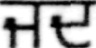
ਜਦ
